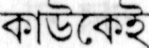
কাউকেই
